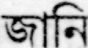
জানি
